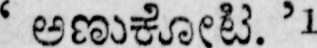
‘ಅಣುಕೋಟಿ.’1.
